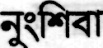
নুংশিবা
